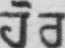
ਹੋਰ
